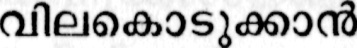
വിലകൊടുക്കാന്‍
